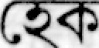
হেক
